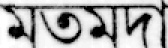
মতমদা
